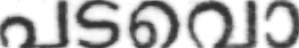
പടവൊ
